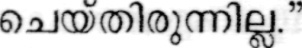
ചെയ്തിരുന്നില്ല.”
